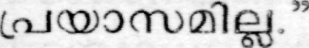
പ്രയാസമില്ല."
